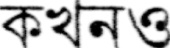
কখনও
